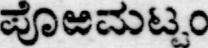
ಪೊಱಮಟ್ಟ೦
